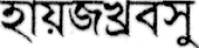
হায়জখ্রবসু
